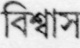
বিশ্বাস
